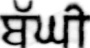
ਬੱਘੀ
